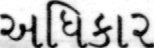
અધિકાર
